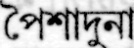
পৈশাদুনা
